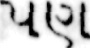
પણ
